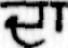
ਦਾ
